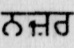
ਨਜ਼ਰ
